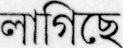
লাগিছে
